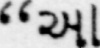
"આ
